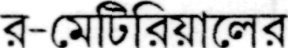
র-মেটিরিয়ালের
